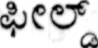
ಫೀಲ್ಡ್
